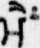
ਮੈਂ
